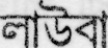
লাউবা
